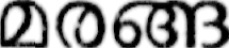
മരങ്ങ
